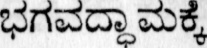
ಭಗವದ್ಧಾಮಕ್ಕೆ
